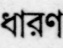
ধারণ
